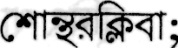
শোন্থরক্লিবা;
